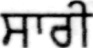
ਸਾਰੀ
